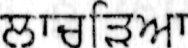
ਲਾਚੜਿਆ
